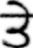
ਤੇ
